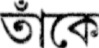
তাঁকে
